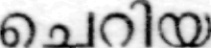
ചെറിയ
